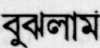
বুঝলাম
